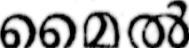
മൈല്‍
